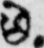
છે.
